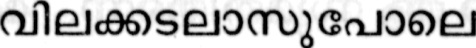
വിലക്കടലാസുപോലെ
